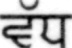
ਵੱਧ
